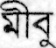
মীবু
